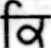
ਕਿ
